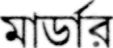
মার্ডার
